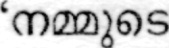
‘നമ്മുടെ
